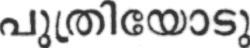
പുത്രിയോടു
